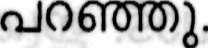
പറഞ്ഞു.
